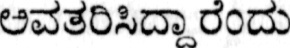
ಅವತರಿಸಿದ್ದಾರೆಂದು
